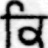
ਕਿ
